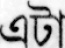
এটা
